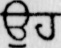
ਉਹ
